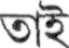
তাই
